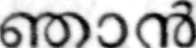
ഞാന്‍
